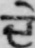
ਦੇ
